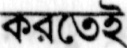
করতেই
